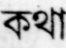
কথা
